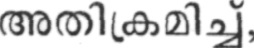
അതിക്രമിച്ച്,
